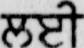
ਲਈ
